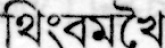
থিংবমখৈ
